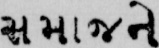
સમાજને
